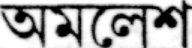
অমলেশ
